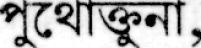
পুথোক্তুনা,
